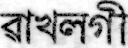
ৱাখলগী
